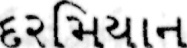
દરમિયાન
